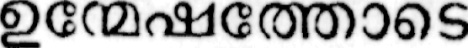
ഉന്മേഷത്തോടെ
